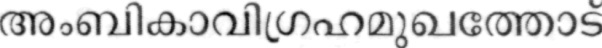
അംബികാവിഗ്രഹമുഖത്തോട്
